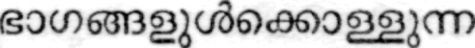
ഭാഗങ്ങളുള്‍ക്കൊള്ളുന്ന
